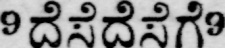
9ದೆಸೆದೆಸೆಗೆ9
